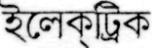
ইলেক্‌ট্রিক
